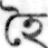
হৈ
